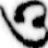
ও
